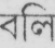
বলি
